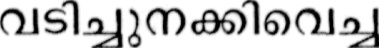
വടിച്ചുനക്കിവെച്ച
